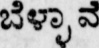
ಬೆಳ್ಳಾವೆ
